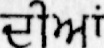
ਦੀਆਂ
